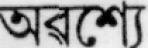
অৱশ্যে
